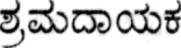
ಶ್ರಮದಾಯಕ
